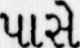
પાસે
